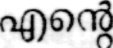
എന്റെ
